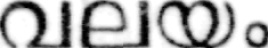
വലയം
